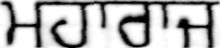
ਮਹਾਰਾਜ
